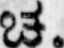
ಚ.
